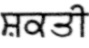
ਸ਼ਕਤੀ
